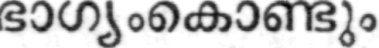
ഭാഗ്യംകൊണ്ടും
